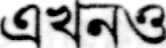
এখনও
